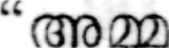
“അമ്മ
